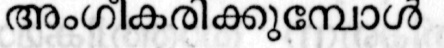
അംഗീകരിക്കുമ്പോള്‍
